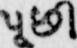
પૂછી
